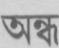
অন্ধ
